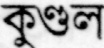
কুণ্ডল
